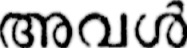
അവള്‍
